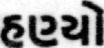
હણ્યો
